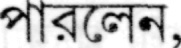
পারলেন,
